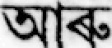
আৰু
